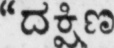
“ದಕ್ಷಿಣ
